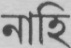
নাহি
